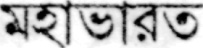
মহাভারত
